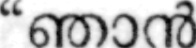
“ഞാന്‍
